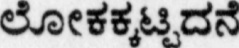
ಲೋಕಕ್ಕಟ್ಟಿದನೆ
